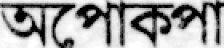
অপোকপা
